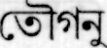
তৌগনু
